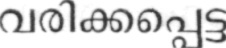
വരിക്കപ്പെട്ട
